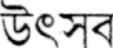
উত্সব
